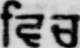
ਵਿਚ
